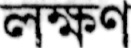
লক্ষণ
